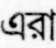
এরা
